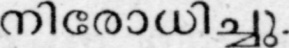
നിരോധിച്ചു.
